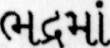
ભદ્રમાં
